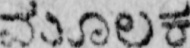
ಮೂಲಕ
